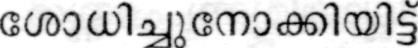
ശോധിച്ചുനോക്കിയിട്ട്
